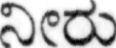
ನೀರು
